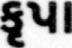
કૃપા
